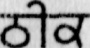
ਠੀਕ
